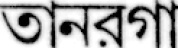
তানরগা
